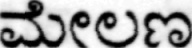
ಮೇಲಣ
